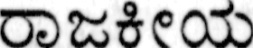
ರಾಜಕೀಯ
